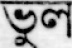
ভুল
